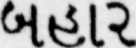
બહાર
